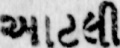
આટલી
